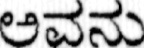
ಅವನು
